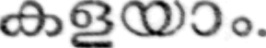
കളയാം.
